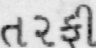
તરફી
